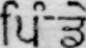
ਪਿੰਡੇ
